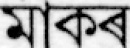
মাকৰ
